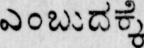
ಎಂಬುದಕ್ಕೆ
